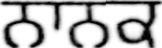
ਨਾਨਕ
